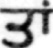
ਤਾਂ
